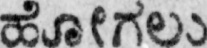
ಹೋಗಲು
